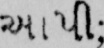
આપી;
